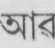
আৱ
